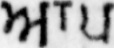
ਆਪ
